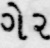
ગેર
